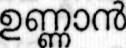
ഉണ്ണാന്‍
